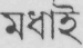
মধাই
